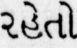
રહેતો
